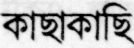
কাছাকাছি
